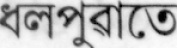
ধলপুৱাতে
